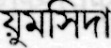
য়ুমসিদা
